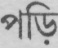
পড়ি
